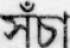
সঁচা
